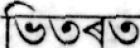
ভিতৰত
